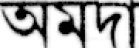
অমদা
